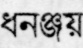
ধনঞ্জয়
